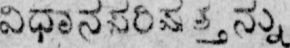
ವಿಧಾನಪರಿಷತ್ತನ್ನು
